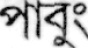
পাবুং
